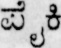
ಪೈಕಿ
